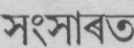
সংসাৰত
